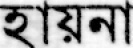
হায়না
